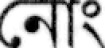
নোং
